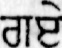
ਗਏ
